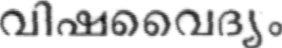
വിഷവൈദ്യം
